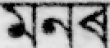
মনৰ
